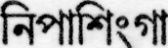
নিপাশিংগা
